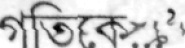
গতিক..',
